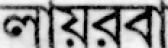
লায়রবা
